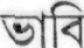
ভাবি
